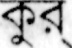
কুর্
